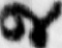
જ
